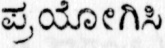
ಪ್ರಯೋಗಿಸಿ
